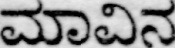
ಮಾವಿನ
